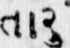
તારું
